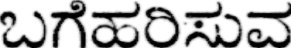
ಬಗೆಹರಿಸುವ
